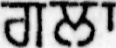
ਗਲਾ
